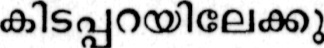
കിടപ്പറയിലേക്കു
